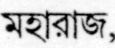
মহারাজ,
